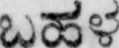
ಬಹಳ
